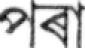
পৰা
